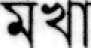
মখা
